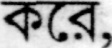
করে,
